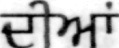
ਦੀਆ
